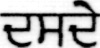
ਦਸਦੇ
